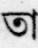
তা
